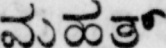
ಮಹತ್
